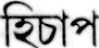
হিচাপ
